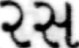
રસ
